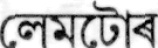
লেমটোৰ
